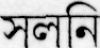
সলনি
